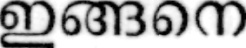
ഇങ്ങനെ
